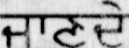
ਜਾਣਦੇ
